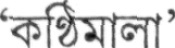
'কণ্ঠিমালা'
